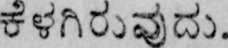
ಕೆಳಗಿರುವುದು.
